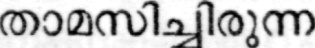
താമസിച്ചിരുന്ന
